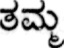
ತಮ್ಮ
